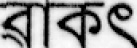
ৱাকৎ
